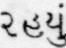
રહયું
